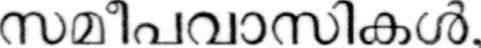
സമീപവാസികള്‍.
